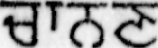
ਚਾਨਣ
